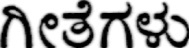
ಗೀತೆಗಳು
